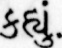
કહ્યું.
